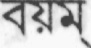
বয়ম্
